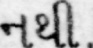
નથી.
